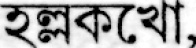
হল্লকখো,
